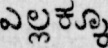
ಎಲ್ಲಕ್ಕೂ
